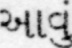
આવું
